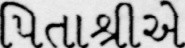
પિતાશ્રીએ
